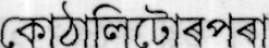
কোঠালিটোৰপৰা
